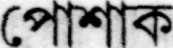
পোশাক
